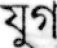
যুগ
